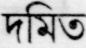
দমিত
